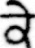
ਕੇ
